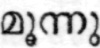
മൂന്നു
